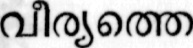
വീര്യത്തെ
